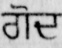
ਗੋਦ
